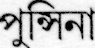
পুন্সিনা
